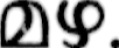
മഴ.
